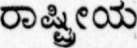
ರಾಷ್ಟ್ರೀಯ
